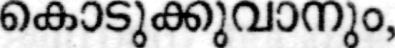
കൊടുക്കുവാനും,
